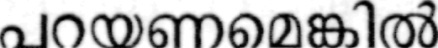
പറയണമെങ്കില്‍
